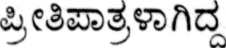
ಪ್ರೀತಿಪಾತ್ರಳಾಗಿದ್ದ
